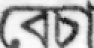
বেচা
